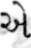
એ
